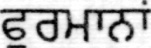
ਫੁਰਮਾਨਾਂ
